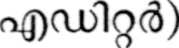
എഡിറ്റര്‍)
